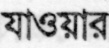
যাওয়ার
